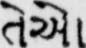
તેઓ
